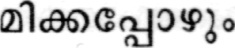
മിക്കപ്പോഴും
